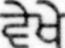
ਵੇਖੇ
